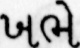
ખભે
